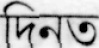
দিনত
